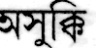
অসুক্কি
